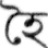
হৈ
